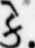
કે.
